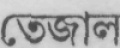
তেজাল
